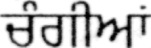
ਚੰਗੀਆਂ
